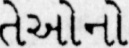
તેઓનો
